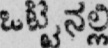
ಒಟ್ಟಿನಲ್ಲಿ
